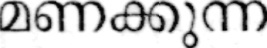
മണക്കുന്ന
